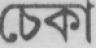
চেকা
